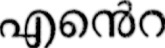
എന്റെ
